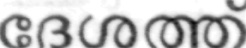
ദേശത്ത്
